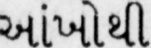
આંખોથી
